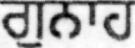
ਗੁਨਾਹ
